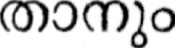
താനും
